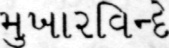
મુખારવિન્દે
